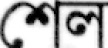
শেল
